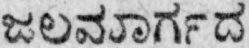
ಜಲಮಾರ್ಗದ
